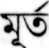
মূর্ত
